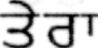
ਤੇਰਾ
